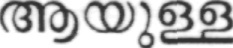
ആയുള്ള
